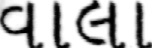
વાલા
